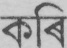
কৰি
